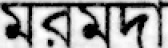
মরমদা
